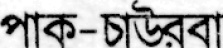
পাক-চাউরবা
